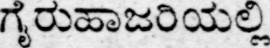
ಗೈರುಹಾಜರಿಯಲ್ಲಿ
